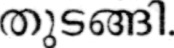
തുടങ്ങി.
